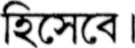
হিসেবে।
